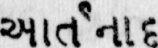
આર્તનાદ
